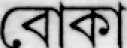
বোকা
